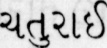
ચતુરાઈ
